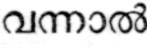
വന്നാല്‍
